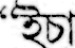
“ইচা
